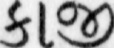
કાજી
